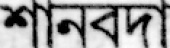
শানবদা
